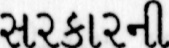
સરકારની
